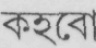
কহবো
